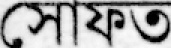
সোফত
